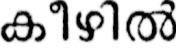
കീഴില്‍
